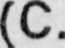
(C.
